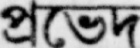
প্রভেদ
